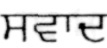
ਸਵਾਦ
